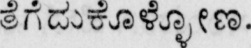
ತೆಗೆದುಕೊಳ್ಳೋಣ.
